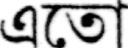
এতো
